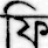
ফি
